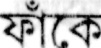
ফাঁকে
